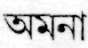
অমনা
